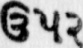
ઉપર
